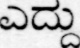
ಎದ್ದು
